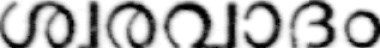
ശ്വരവാദം
